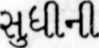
સુધીની
